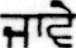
ਜਾਵੇ
